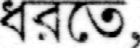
ধরতে,
